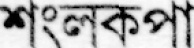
শংলকপা
